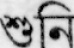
শুনি
